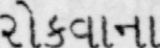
રોકવાના
